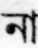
না
